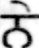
ਨੇ
